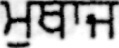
ਮੁਥਾਜ
